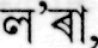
ল'ৰা,
